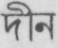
দীন
